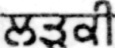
ਲੜਕੀ
